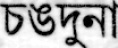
চঙদুনা
